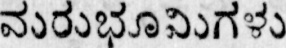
ಮರುಭೂಮಿಗಳು
